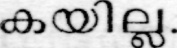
കയില്ല.
